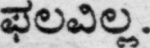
ಫಲವಿಲ್ಲ.
